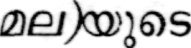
മല)യുടെ
